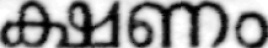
ക്ഷണം
